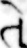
તે
